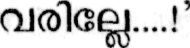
വരില്ലേ....!’
